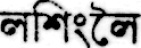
লশিংলৈ
